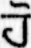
ਹੋ
